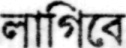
লাগিবে
